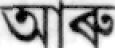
আৰু
